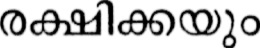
രക്ഷിക്കയും
